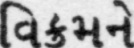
વિક્રમને
